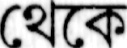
থেকে
